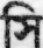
সি
